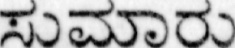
ಸುಮಾರು
